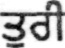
ਤੁਰੀ
